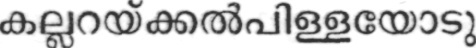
കല്ലറയ്ക്കല്‍പിള്ളയോടു
